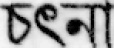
চৎনা
